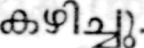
കഴിച്ചു.
